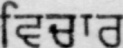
ਵਿਚਾਰ
